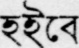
হইবে
